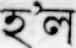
হ'ল
